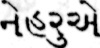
નેહરુએ
